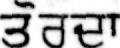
ਤੋਰਦਾ
